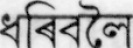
ধৰিবলৈ
